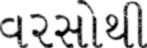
વરસોથી
